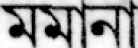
মমানা
